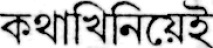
কথাখিনিয়েই
